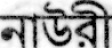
নাউরী
